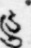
હું
